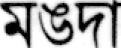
মঙদা
